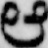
ಆ
